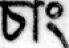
চাং
